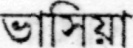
ভাসিয়া
